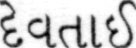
દેવતાઈ
